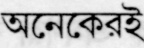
অনেকেরই
